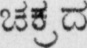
ಚಕ್ರದ
